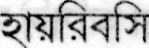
হায়রিবসি
